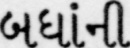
બધાંની
